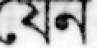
যেন
